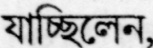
যাচ্ছিলেন,
